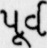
પૂર્વ
